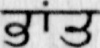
ਭਾਂਤ
